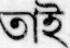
তাই
